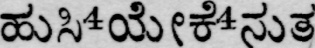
ಹುಸಿ4ಯೇಕೆ4ನುತ
